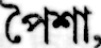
পৈশা,
